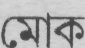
মোক
